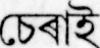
চেৰাই
